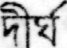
দীর্ঘ
